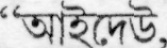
"আইদেউ,
